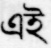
এই
